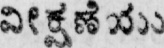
ವೀಕ್ಷಣೆಯು
